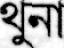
থুনা
